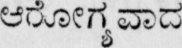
ಆರೋಗ್ಯವಾದ
